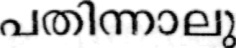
പതിന്നാലു
